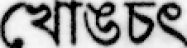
খোঙচৎ
